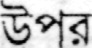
উপর
